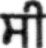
ਸੀ
